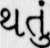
થતું
